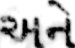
અને
